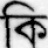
কি
